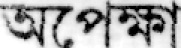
অপেক্ষা
